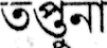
তপ্তুনা
